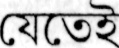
যেতেই
